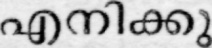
എനിക്കു
